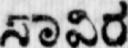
ಸಾವಿರ
